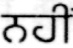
ਨਹੀਂ
